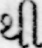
થી
